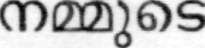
നമ്മുടെ
